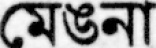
মেঙনা
